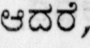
ಆದರೆ,
